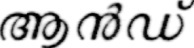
ആന്‍ഡ്
